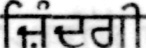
ਜ਼ਿੰਦਗੀ
